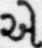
એ
